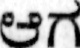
ಆಗ
